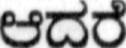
ಆದರೆ
